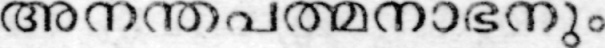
അനന്തപത്മനാഭനും
